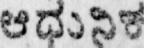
ಆಧುನಿಕ
